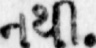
નથી.
